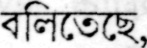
বলিতেছে,
